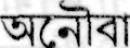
অনৌবা
